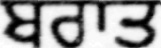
ਬਰਾਤ
